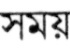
সময়
